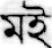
মই
